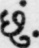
છું.
